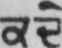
ਕਦੇ
